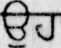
ਉਹ
